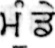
ਮੁੰਡੇ
